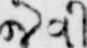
જેવી
